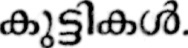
കുട്ടികള്‍.
